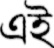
এই
